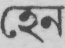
হেন
